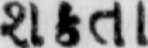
શકતા
